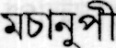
মচানুপী
